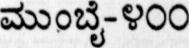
ಮುಂಬೈ-೪೦೦
